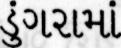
ડુંગરામાં
